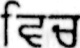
ਵਿਚ
